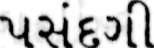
પસંદગી
